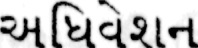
અધિવેશન
